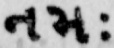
નમઃ
